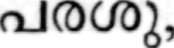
പരശു,
